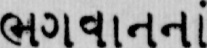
ભગવાનનાં
